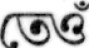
তেওঁ
